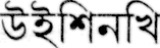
উইশিনখি
